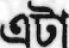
এটা
